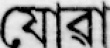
যোৱা
